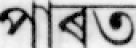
পাৰত
